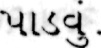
પાડવું.
